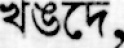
খঙদে,
